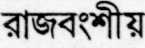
রাজবংশীয়
